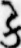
કે
